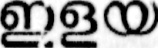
ഇളയ
